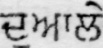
ਦੁਆਲੇ
